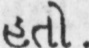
હતો.
